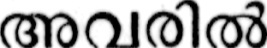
അവരില്‍
